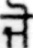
ਜੋ
